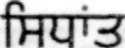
ਸਿਧਾਂਤ
